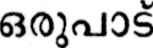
ഒരുപാട്
